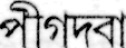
পীগদবা
